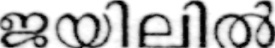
ജയിലില്‍
